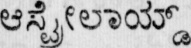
ಆಸ್ಟ್ರೇಲಾಯ್ಡ್
